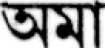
অমা
